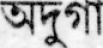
অদুগা
